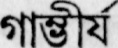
গাম্ভীর্য
